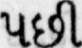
પછી
